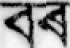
বৰ
